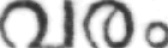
വരം
